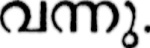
വന്നു.
